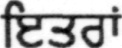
ਇਤਰਾਂ
